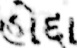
હોદ્દા
